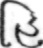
હિ
